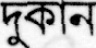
দুকান
